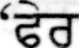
'ਫੇਰ
